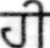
ਹੀ
